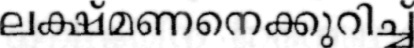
ലക്ഷ്മണനെക്കുറിച്ച്
